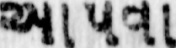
આપવા
